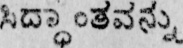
ಸಿದ್ದಾಂತವನ್ನು
